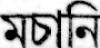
মচানী
